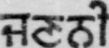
ਜਣਨੀ
